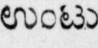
ಉಂಟು
